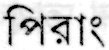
পিরাং
